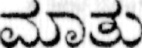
ಮಾತು
